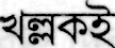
খল্লকই
